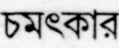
চমত্কার
